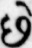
છે
